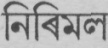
নিৰিমল
